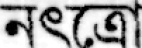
নৎত্রো
